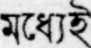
মধ্যেই
